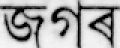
জগৰ
